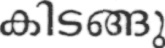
കിടങ്ങു
